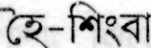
হৈ-শিংবা
